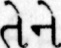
તેને
